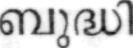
ബുദ്ധി
